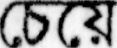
চেয়ে
